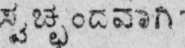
ಸ್ವಚ್ಛಂದವಾಗಿ
